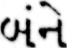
બંને
